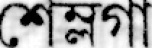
শেম্লগা
